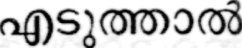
എടുത്താല്‍
